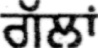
ਗੱਲਾਂ
